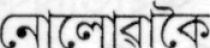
নোলোৱাকৈ
